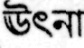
ঊৎনা
